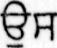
ਉਸ
